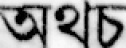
অথচ
